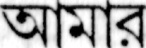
আমার
